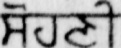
ਸੋਹਣੀ
